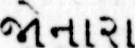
જોનારા
